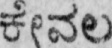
ಕೇವಲ
